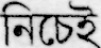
নিচেই
